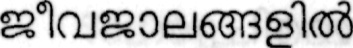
ജീവജാലങ്ങളില്‍
